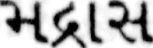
મદ્રાસ
